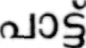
പാട്ട്
